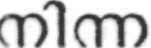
നിന്ന
